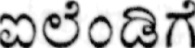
ಐಲೆಂಡಿಗೆ
